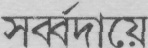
সৰ্ব্বদায়ে
